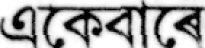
একেবাৰে
